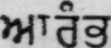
ਆਰੰਭ
